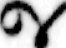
જ
